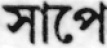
সাপে
